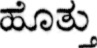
ಹೊತ್ತು
